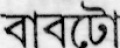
বাবটো
